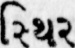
સ્થિર
